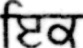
ਇਕ
